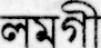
লমগী
